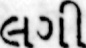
લગી
